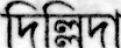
দিল্লিদা
